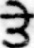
ਤੇ
